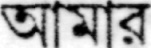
আমার
